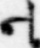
ન
